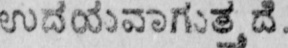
ಉದಯವಾಗುತ್ತದೆ.
